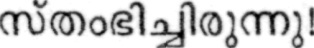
സ്തംഭിച്ചിരുന്നു!
